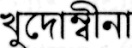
খুদোম্বীনা
